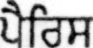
ਪੈਰਿਸ
